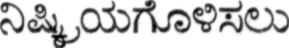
ನಿಷ್ಕ್ರಿಯಗೊಳಿಸಲು
